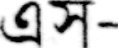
এস-
